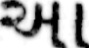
આ
